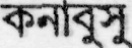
কনাবুসু
